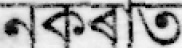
নকৰাত
